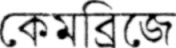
কেমব্রিজে
